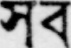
সব
